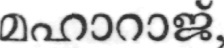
മഹാറാജ്,
